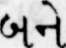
બને
